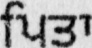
ਪਿਤਾ
